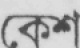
কেশ
